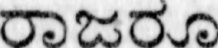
ರಾಜರೂ
